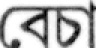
বেচা
